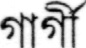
গার্গী
